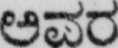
ಅವರ
